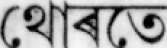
থোৰতে
